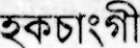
হকচাংগী
